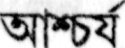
আশ্চর্য
